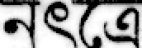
নৎত্রে
